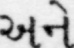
અને
